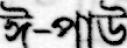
ঈ-পাউ
